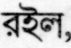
রইল,
